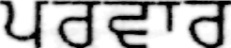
ਪਰਵਾਰ
